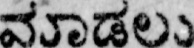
ಮಾಡಲು
